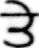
ਤੇ
